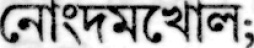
নোংদমখোল;
